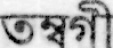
তম্বগী
